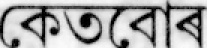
কেতবোৰ
